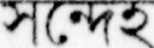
সন্দেহ
